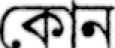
কোন
